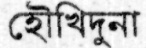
হৌখিদুনা
